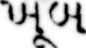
ખૂબ
